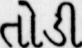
તોડી
